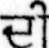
ਦੀ
